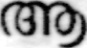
ആ
